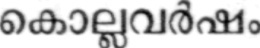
കൊല്ലവര്‍ഷം
